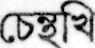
চেন্থখি
